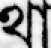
থা
